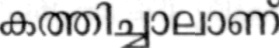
കത്തിച്ചാലാണ്
